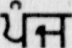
ਪੰਜ
